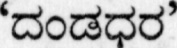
‘ದಂಡಧರ’
